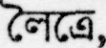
লৈত্রে,
